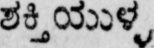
ಶಕ್ತಿಯುಳ್ಳ
